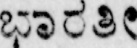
ಭಾರತೀ
